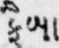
ફૈબા
